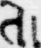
તો
